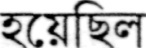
হয়েছিল
